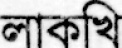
লাকখি
